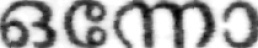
ഒന്നോ
